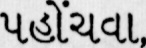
પહોંચવા,
